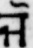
ਜੋ
